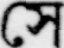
সে
